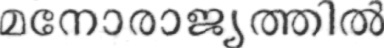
മനോരാജ്യത്തില്‍
